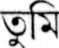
তুমি
